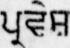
ਪ੍ਰਵੇਸ਼
